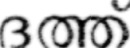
ദത്ത്
